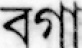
বগা
